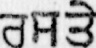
ਰਸਤੇ
